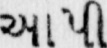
આપી
